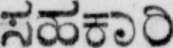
ಸಹಕಾರಿ
